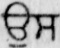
ਉਸ
